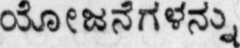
ಯೋಜನೆಗಳನ್ನು
